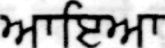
ਆਇਆ
